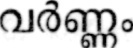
വര്‍ണ്ണം
